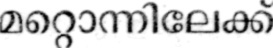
മറ്റൊന്നിലേക്ക്
